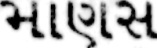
માણસ
